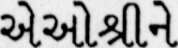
એઓશ્રીને
